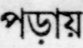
পড়ায়
